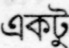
একটু
